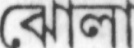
ঝোলা
